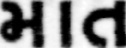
માત
